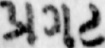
પ્રગટ
